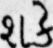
શકે
